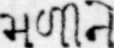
મળીને
